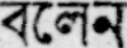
বলেন
